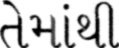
તેમાંથી
